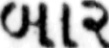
બાર
